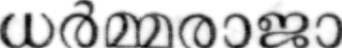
ധര്‍മ്മരാജാ
